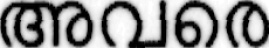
അവരെ
